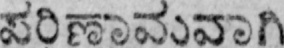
ಪರಿಣಾಮವಾಗಿ
